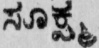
ಸೂಕ್ಷ್ಮ
